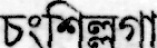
চংশিল্লগা
